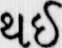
થઈ
